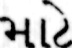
માટે
